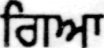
ਗਿਆ
